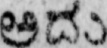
ಅದು
